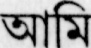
আমি
